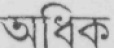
অধিক
